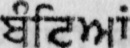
ਬੰਟਿਆਂ
